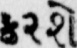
કરશે
